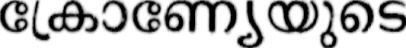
ക്രോണ്യേയുടെ
